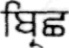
ਬ੍ਰਿਛ
